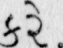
કરે.
